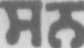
ਸਨ
